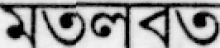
মতলবত
